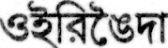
ওইরিঙৈদা
